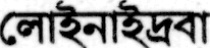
লোইনাইদ্রবা
